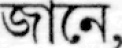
জানে,
